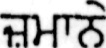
ਜ਼ਮਾਨੇ
